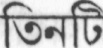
তিনটি
